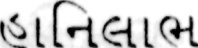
હાનિલાભ
